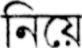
নিয়ে
